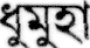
ধুমুহা
